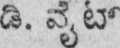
ಡಿ.ವೈಟ್
